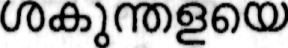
ശകുന്തളയെ
